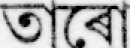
তাৰো
